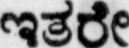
ಇತರೇ
